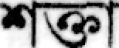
শক্তা
